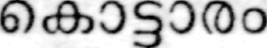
കൊട്ടാരം
